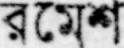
রমেশ
